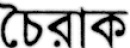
চৈরাক
